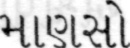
માણસો
